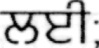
ਲਈ;
